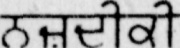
ਨਜ਼ਦੀਕੀ
